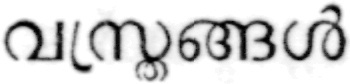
വസ്ത്രങ്ങള്‍
